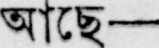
আছে—
